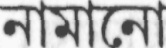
নামানো
